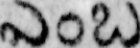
ಎಂಬ
